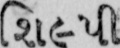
શિલ્પી
